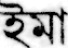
ইমা
